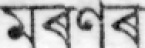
মৰণৰ
